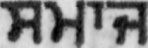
ਸਮਾਜ
